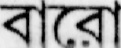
বারো
